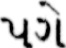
પગે
